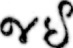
જઈ
